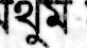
মথুম
